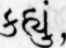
કહ્યું,
